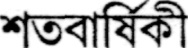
শতবার্ষিকী
